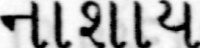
નાશાય
